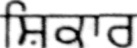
ਸ਼ਿਕਾਰ
